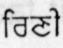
ਰਿਣੀ
